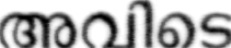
അവിടെ
